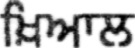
ਖ਼ਿਆਲ
